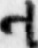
ન
